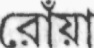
রোঁয়া
